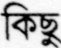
কিছু
